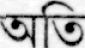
অতি
